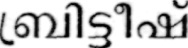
ബ്രിട്ടീഷ്
